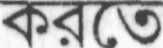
করতে
